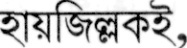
হায়জিল্লকই,
